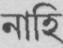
নাহি
